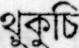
থুকুচি
